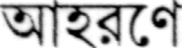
আহরণে
